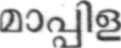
മാപ്പിള
